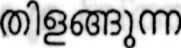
തിളങ്ങുന്ന
